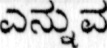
ಎನ್ನುವ
